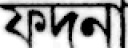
ফদনা
